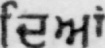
ਦਿਆਂ
